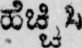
ಹೆಚ್ಚಿಸಿ
